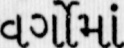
વર્ગોમાં
